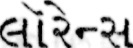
લૉરેન્સ
